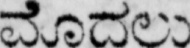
ಮೊದಲು
